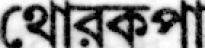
থোরকপা
